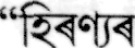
"হিৰণ্যৰ
